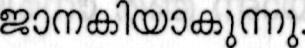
ജാനകിയാകുന്നു.
